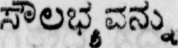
ಸೌಲಭ್ಯವನ್ನು
